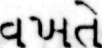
વખતે
